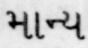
માન્ય
